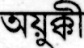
অয়ুক্কী
